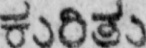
ಕುರಿತು
